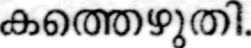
കത്തെഴുതി.
